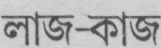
লাজ-কাজ
